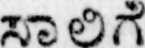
ಸಾಲಿಗೆ
